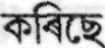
কৰিছে
